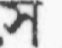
সে
